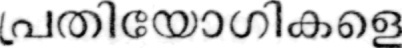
പ്രതിയോഗികളെ
